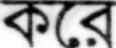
করে
